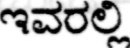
ಇವರಲ್ಲಿ
